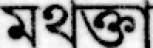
মথক্তা
